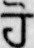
ਹੋ
